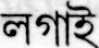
লগাই
